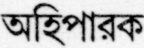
অহিপারক
